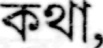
কথা,
